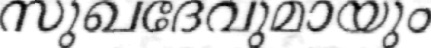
സുഖദേവുമായും
